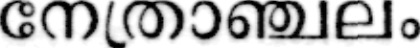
നേത്രാഞ്ചലം
